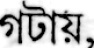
গটায়,
